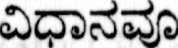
ವಿಧಾನವೂ
